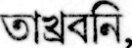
তাখ্রবনি,
